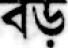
বড়
